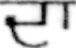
ਦਾ
